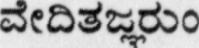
ವೇದಿತಜ್ಞರುಂ
